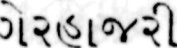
ગેરહાજરી
